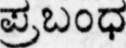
ಪ್ರಬಂಧ
